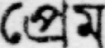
প্রেম
